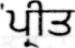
'ਪ੍ਰੀਤ
